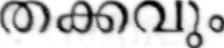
തക്കവും
